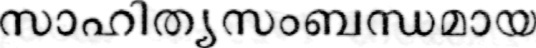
സാഹിത്യസംബന്ധമായ
